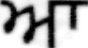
ਆ
